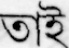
তাই
